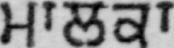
ਮਾਲਕਾ
